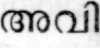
അവി
